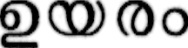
ഉയരം
